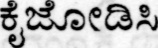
ಕೈಜೋಡಿಸಿ
